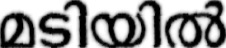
മടിയില്‍
